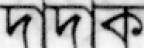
দাদাক
